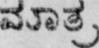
ಮಾತ್ರ
